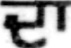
ਦਾ
